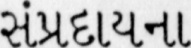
સંપ્રદાયના
